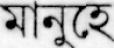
মানুহে
